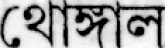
থোঙ্গাল
